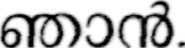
ഞാന്‍.
